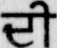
ਦੀ
